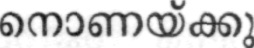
നൊണയ്ക്കു
